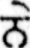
ਨੇ
